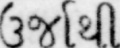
ઉર્જાથી
